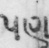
પણ
